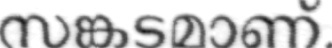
സങ്കടമാണ്.
